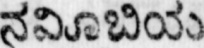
ನಮೀಬಿಯ
